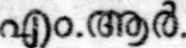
എം.ആര്‍.
